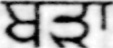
ਬੜਾ
